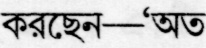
করছেন–‘অত
